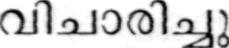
വിചാരിച്ചു
